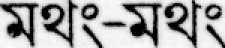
মথং-মথং
